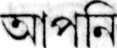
আপনি
